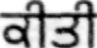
ਕੀਤੀ
